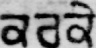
ਕਰਕੇ
